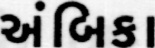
અંબિકા
